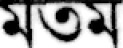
মতম
